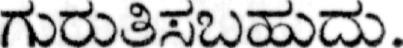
ಗುರುತಿಸಬಹುದು.
